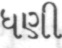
ધણી
